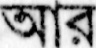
আর
